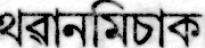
থৱানমিচাক
